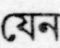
যেন
